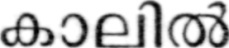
കാലില്‍
